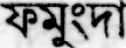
ফমুংদা
